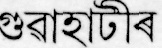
গুৱাহাটীৰ
